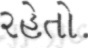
રહેતો.
